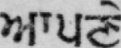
ਆਪਣੇ
